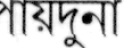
পায়দুনা
